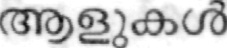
ആളുകള്‍
